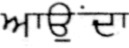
ਆਉਂਦਾ
